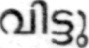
വിട്ടു
